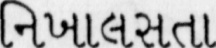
નિખાલસતા
